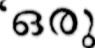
‘ഒരു
